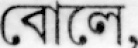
বোলে,
